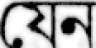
যেন
